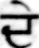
ਦੇ
